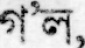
গ'ল,
